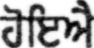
ਹੋਇਐ
